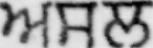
ਅਸਲ
